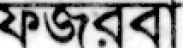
ফজরবা
